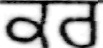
ਕਰ
